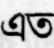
এত
